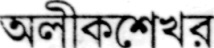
অলীকশেখর
